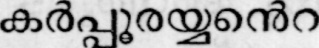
കര്‍പ്പൂരയ്യന്റെ
